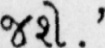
જશે.'
